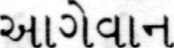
આગેવાન
